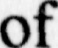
of
